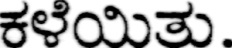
ಕಳೆಯಿತು.
